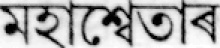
মহাশ্বেতাৰ
